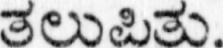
ತಲುಪಿತು.
